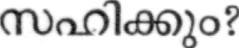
സഹിക്കും?
